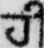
ਹੀ
